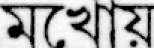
মখোয়
